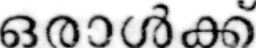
ഒരാള്‍ക്ക്
